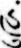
હું
